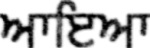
ਆਇਆ
